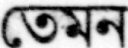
তেমন
